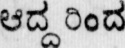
ಆದ್ದರಿಂದ
